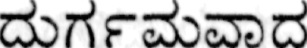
ದುರ್ಗಮವಾದ
